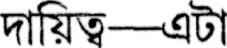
দায়িত্ব-এটা
